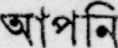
আপনি
